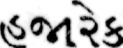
હજારેક
